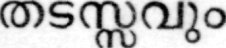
തടസ്സവും
